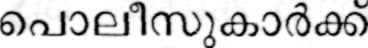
പൊലീസുകാര്‍ക്ക്
